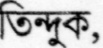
তিন্দুক,
